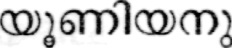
യൂണിയനു
